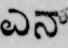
ಎನ್
